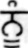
ਨੂੰ
